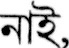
নাই,
